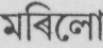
মৰিলো
